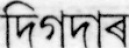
দিগদাৰ
